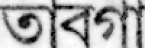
তাবগা
